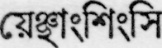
য়েঞ্ছাংশিংদু
